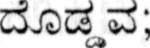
ದೊಡ್ಡವ;
